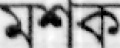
মশক
